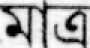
মাত্র
